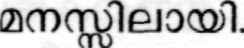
മനസ്സിലായി.
